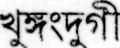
খুঙ্গংদুগী
